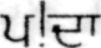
ਪੀਦਾ
